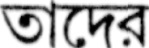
তাদের
